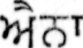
ਐਨਾ
